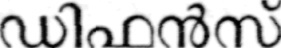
ഡിഫന്‍സ്
